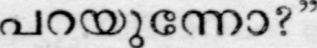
പറയുന്നോ?''
